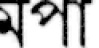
মপা
